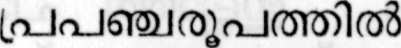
പ്രപഞ്ചരൂപത്തില്‍
